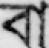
বা
